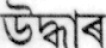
উদ্ধাৰ
